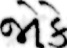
જોકે
